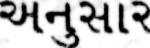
અનુસાર
